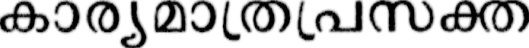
കാര്യമാത്രപ്രസക്ത
